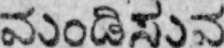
ಮಂಡಿಸುವ
